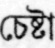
চেষ্টা
